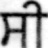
ਸੀ
